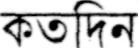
কতদিন
